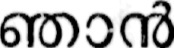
ഞാന്‍
